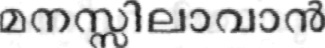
മനസ്സിലാവാന്‍
